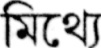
মিথ্যে
